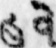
હવે
